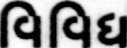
વિવિધ
